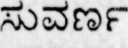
ಸುವರ್ಣ
